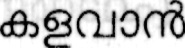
കളവാന്‍
